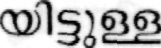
യിട്ടുള്ള
